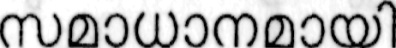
സമാധാനമായി
